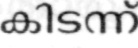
കിടന്ന്
